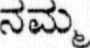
ನಮ್ಮ
